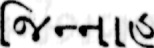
જિન્નાહ
